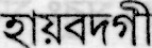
হায়বদগী
